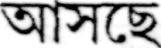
আসছে
